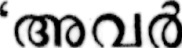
‘അവര്‍
